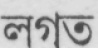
লগত
